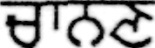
ਚਾਨਣ
